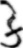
કે
